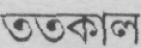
ততকাল
